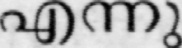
എന്നു
